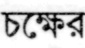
চক্ষের
